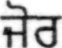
ਜੋਰ
